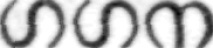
ഗഗന
